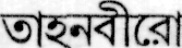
তাহনবীরো
